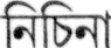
নিচিনা
